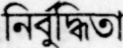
নির্বুদ্ধিতা
